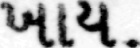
ખાય.
